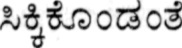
ಸಿಕ್ಕಿಕೊಂಡಂತೆ
